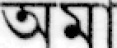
অমা
